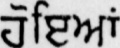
ਹੋਇਆਂ
